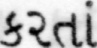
કરતાં
